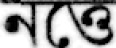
নত্তে
